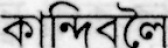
কান্দিবলৈ
